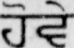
ਹੋਵੇ
